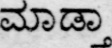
ಮಾಡ್ತಾ
